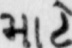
માટે
